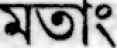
মতাং
